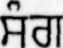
ਸੰਗ
